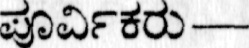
ಪೂರ್ವಿಕರು-
